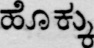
ಹೊಕ್ಕು
